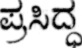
ಪ್ರಸಿದ್ಧ
